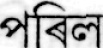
পৰিল
